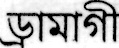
ড্রামাগী
